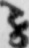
કે
